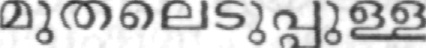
മുതലെടുപ്പുള്ള
